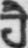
ਹੈ
